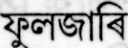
ফুলজাৰি
